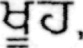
ਖੂਹ,
